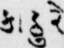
કાઠુરે
